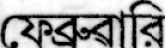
ফেব্রুৱারি
